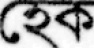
হেক
